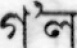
গ'ল
